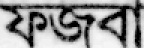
ফজবা
